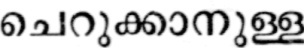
ചെറുക്കാനുള്ള
